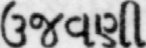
ઉજવણી
